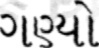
ગણ્યો
